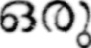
ഒരു
